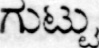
ಗುಟ್ಟು
